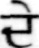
ਦੇ
